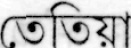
তেতিয়া
